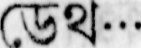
ডেথ...
